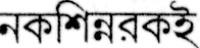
নকশিন্নরকই
